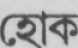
হোক
